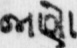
જાણો
